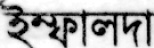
ইম্ফালদা
